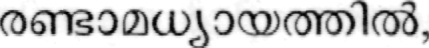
രണ്ടാമധ്യായത്തില്‍,
